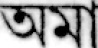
অমা
